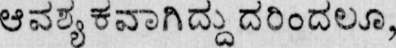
ಆವಶ್ಯಕವಾಗಿದ್ದುದರಿಂದಲೂ,
